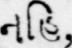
નહિ,
